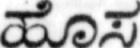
ಹೊಸ
